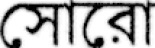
সোরো
